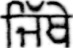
ਜਿੱਥੇ
